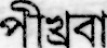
পীখ্রবা
